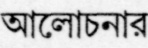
আলোচনার
